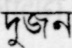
দুজন
